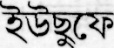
ইউছুফে
